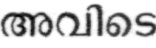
അവിടെ
